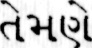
તેમણે
